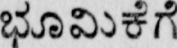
ಭೂಮಿಕೆಗೆ
